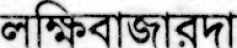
লক্ষিবাজারদা
